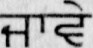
ਜਾਵੇ
